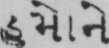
હમોને
